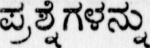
ಪ್ರಶ್ನೆಗಳನ್ನು
